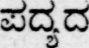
ಪದ್ಯದ
